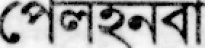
পেলহনবা
